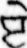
ਏ
